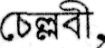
চেল্লবী,
